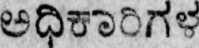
ಅಧಿಕಾರಿಗಳ
